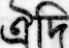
ঐদি
